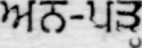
ਅਨ-ਪੜ੍ਹ
